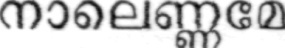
നാലെണ്ണമേ
